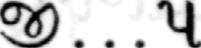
જી...૫
